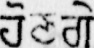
ਹੋਣਗੇ
